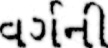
વર્ગની
